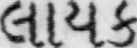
લાયક
